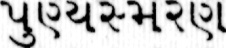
પુણ્યસ્મરણ
